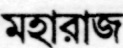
মহারাজ
